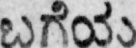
ಬಗೆಯ
